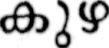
കുഴ
